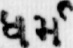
ધર્મ
